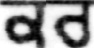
ਕਰ
